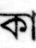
কা
